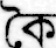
কৈ
